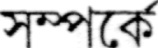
সম্পর্কে
